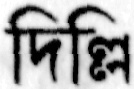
দিল্লি
